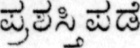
ಪ್ರಶಸ್ತಿಪಡೆ
